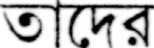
তাদের
